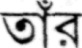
তাঁর
